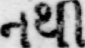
નથી
